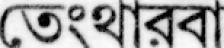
তেংথারবা
